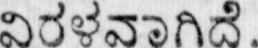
ವಿರಳವಾಗಿದೆ.
